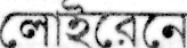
লোইরেনে
